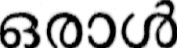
ഒരാള്‍
